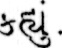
કહ્યું.
